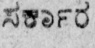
ಸರ್ಕಾರ
